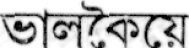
ভালকৈয়ে
